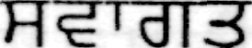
ਸਵਾਗਤ
